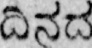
ದಿನದ
